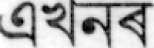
এখনৰ
